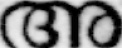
അ
